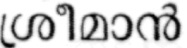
ശ്രീമാന്‍
